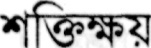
শক্তিক্ষয়
